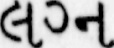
લગ્ન
